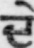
ਦੇ
